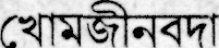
খোমজীনবদা
